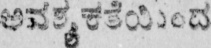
ಅವಶ್ಯಕತೆಯಿಂದ
